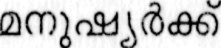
മനുഷ്യര്‍ക്ക്
